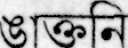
ঙাক্তনি
